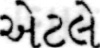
એટલે
